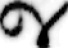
જ
